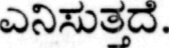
ಎನಿಸುತ್ತದೆ.
